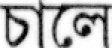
চালে
